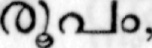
രൂപം,
